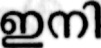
ഇനി
